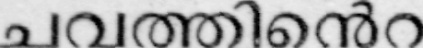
ചവത്തിന്റെ
